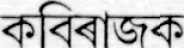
কবিৰাজক
